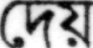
দেয়
